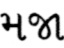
મજા
